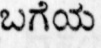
ಬಗೆಯ
